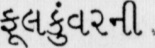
ફૂલકુંવરની
